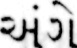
અંગે
